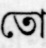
তো
